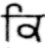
ਕਿ
